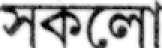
সকলো
